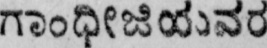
ಗಾಂಧೀಜಿಯವರ
